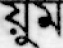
য়ুম
